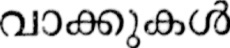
വാക്കുകള്‍
